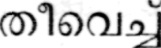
തീവെച്ച്
